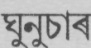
ঘুনুচাৰ
